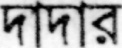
দাদার
